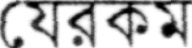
যেরকম
